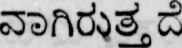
ವಾಗಿರುತ್ತದೆ
